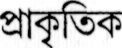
প্রাকৃতিক
